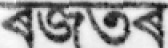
ৰজতৰ
